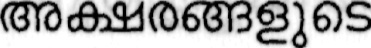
അക്ഷരങ്ങളുടെ
